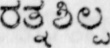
ರತ್ನಶಿಲ್ಪ
